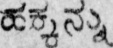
ಹಕ್ಕನ್ನು
